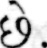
છે.
